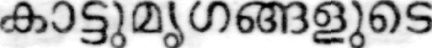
കാട്ടുമൃഗങ്ങളുടെ
